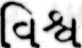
વિશ્વ
